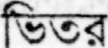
ভিতর
